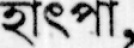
হাৎপা,
